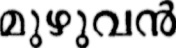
മുഴുവന്‍
